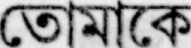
তোমাকে
